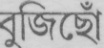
বুজিছোঁ
